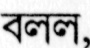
বলল,
